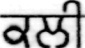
ਕਲੀ
